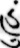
હું
